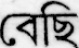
বেছি
